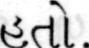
હતો.
